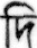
দি
